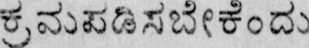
ಕ್ರಮಪಡಿಸಬೇಕೆಂದು
